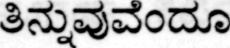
ತಿನ್ನುವುವೆಂದೂ
